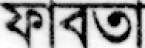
ফাবতা
